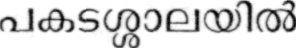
പകടശ്ശാലയില്‍
